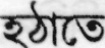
হঠাতে
